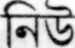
নিউ
